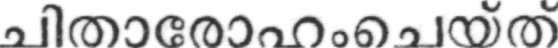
ചിതാരോഹംചെയ്ത്
